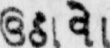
ઉઠાવો
